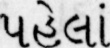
પહેલાં
